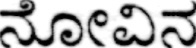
ನೋವಿನ
